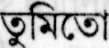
তুমিতো
